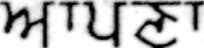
ਆਪਣਾ
